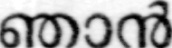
ഞാന്‍
